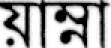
য়াম্না
